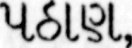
પઠાણ,
